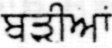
ਬੜੀਆਂ
